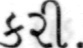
કરી.
